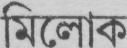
মিলোক
